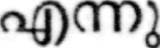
എന്നു
